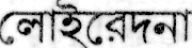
লোইরেদনা
